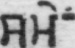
ਸਮੇਂ
